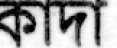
কাদা
